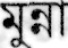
মুন্না
